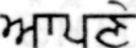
ਆਪਣੇ
